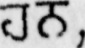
ਹਨ,
